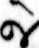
જે
